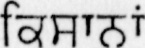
ਕਿਸਾਨਾਂ
